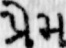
પ્રેમ
